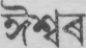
ঈশ্বৰ
